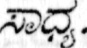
ಸಾಧ್ಯ.
